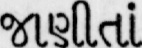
જાણીતાં
